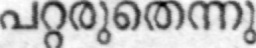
പറ്റരുതെന്നു
